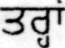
ਤਰ੍ਹਾਂ
